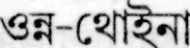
ওন্ন-থোইনা
